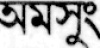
অমসুং
